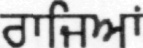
ਰਾਜਿਆਂ
